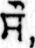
ਸੌ,
